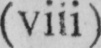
(viii)
